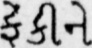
ફેંકીને
